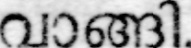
വാങ്ങി.
